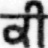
ਕੀ
